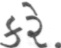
કરે.
